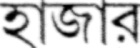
হাজার
